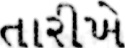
તારીખે
